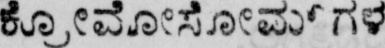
ಕ್ರೋಮೋಸೋಮ್‌ಗಳ
